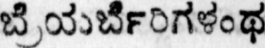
ಬ್ರೆಯರ್ಬೆರಿಗಳಂಥ
